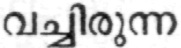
വച്ചിരുന്ന
